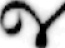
જ
